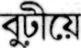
বুঢ়ীয়ে
